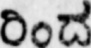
ರಿಂದ
